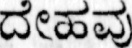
ದೇಹವು
